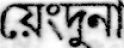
য়েংদুনা
